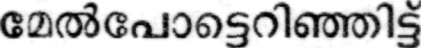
മേല്‍പോട്ടെറിഞ്ഞിട്ട്
